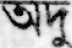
অদু
